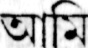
আমি
